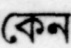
কেন
